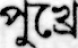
পুখ্রে
